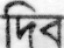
দিব
